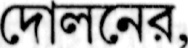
দোলনের,
